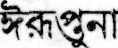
ঈরূপ্তুনা
